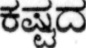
ಕಷ್ಟದ
